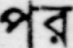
পর
